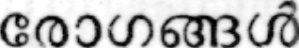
രോഗങ്ങള്‍
